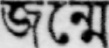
জন্মে
